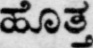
ಹೊತ್ತ
